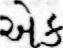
એક
